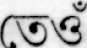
তেওঁ
